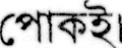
পোকই।
